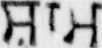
ਸ਼ਾਮ
